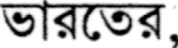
ভারতের,
